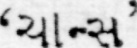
'ચાન્સ'
